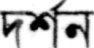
দর্শন
